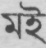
মই
